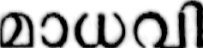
മാധവി
